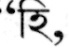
“হি,
